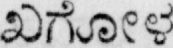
ಖಗೋಳ
